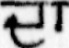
ਦਾ
